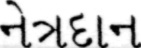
નેત્રદાન
